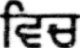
ਵਿਚ
